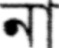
না
